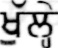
ਖੁੱਲ੍ਹੇ
